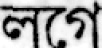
লগে
